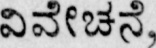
ವಿವೇಚನೆ,
